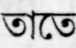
তাতে
